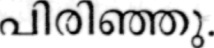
പിരിഞ്ഞു.
